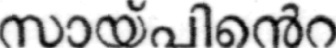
സായ്പിന്റെ
